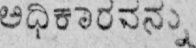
ಅಧಿಕಾರವನ್ನು
